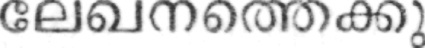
ലേഖനത്തെക്കു
